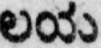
ಲಯ
